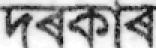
দৰকাৰ
